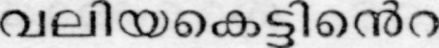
വലിയകെട്ടിന്റെ
